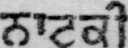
ਨਾਟਕੀ
